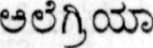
ಅಲೆಗ್ರಿಯಾ
